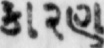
કારણ
